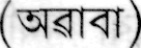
(অৱাবা)
